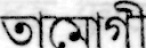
তামোগী
